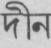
দীন
